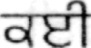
ਕਈ
